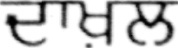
ਦਾਖ਼ਲ
